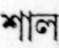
শাল
